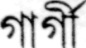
গার্গী
